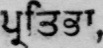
ਪ੍ਰਤਿਭਾ,
